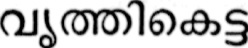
വൃത്തികെട്ട
